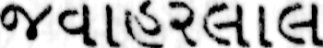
જવાહરલાલ
